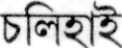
চলিহাই
